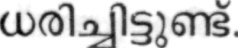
ധരിച്ചിട്ടുണ്ട്.
